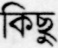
কিছু
